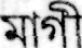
মাগী
